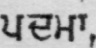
ਪਦਮਾ,
